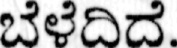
ಬೆಳೆದಿದೆ.
